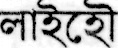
লাইহৌ
